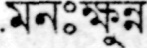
মনঃক্ষুন্ন
